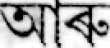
আৰু
